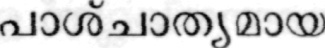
പാശ്ചാത്യമായ
